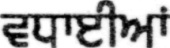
ਵਧਾਈਆਂ
